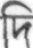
দি
